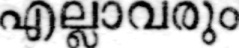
എല്ലാവരും
